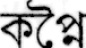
কপ্নৈ
